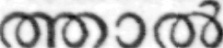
ത്താല്‍
